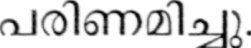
പരിണമിച്ചു.
